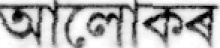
আলোকৰ
